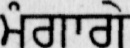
ਮੰਗਾਗੇ
